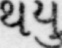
થયુ
